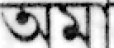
অমা
